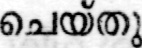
ചെയ്തു
